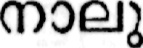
നാലു
